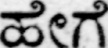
ಹೇಗೆ
